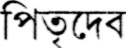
পিতৃদেব
